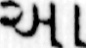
આ
